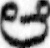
ಆ
